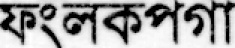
ফংলকপগা
